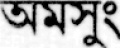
অমসুং
